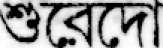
শুরেদো
